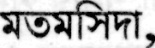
মতমসিদা,
